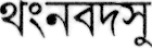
থংনবদসু
